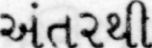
અંતરથી
